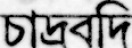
চাদ্রবদি
